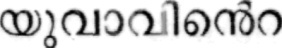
യുവാവിന്റെ
